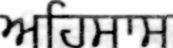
ਅਹਿਸਾਸ
